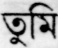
তুমি
